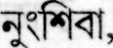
নুংশিবা,
